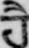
ਹੈ
